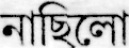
নাছিলো
